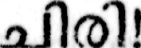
ചിരി!
